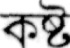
কষ্ট
